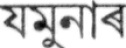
যমুনাৰ
